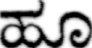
ಹೂ
